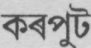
কৰপুট
